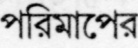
পরিমাপের
